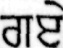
ਗਏ
